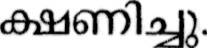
ക്ഷണിച്ചു.
